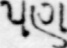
પણ
